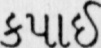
કપાઈ
